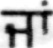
ਜਾਂ
